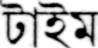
টাইম
